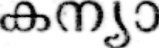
കന്യാ
